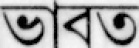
ভাবত
